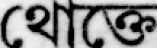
থোক্তে
